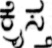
ಕ್ರೈಸ್ತ
